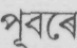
পূবৰে
